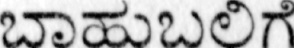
ಬಾಹುಬಲಿಗೆ
